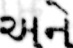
અને
